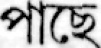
পাছে
